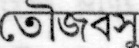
তৌজবসু
